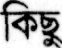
কিছু
